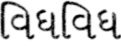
વિધવિધ
